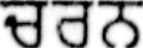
ਚਰਨ
